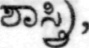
ಶಾಸ್ತ್ರಿ),
